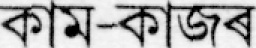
কাম-কাজৰ
